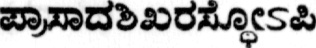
ಪ್ರಾಸಾದಶಿಖರಸ್ಥೋsಪಿ
